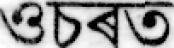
ওচৰত
